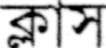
ক্লাস
